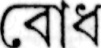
বোধ
